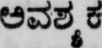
ಅವಶ್ಯಕ
